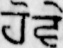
ਹੋਵੇ
